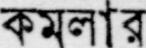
কমলার
